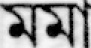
মমা
